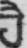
ਹੈ
